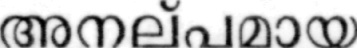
അനല്പമായ
